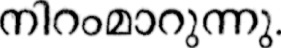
നിറംമാറുന്നു.
